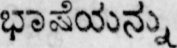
ಭಾಷೆಯನ್ನು
